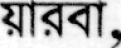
য়ারবা,
